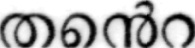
തന്റെ
